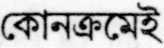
কোনক্রমেই
